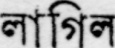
লাগিল
